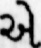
એ
